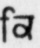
ਕਿ
